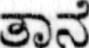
ತಾನೆ
